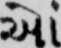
ઓં
